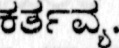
ಕರ್ತವ್ಯ.
